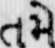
તમે
